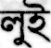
লুই
